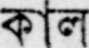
কাল
